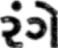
રંગે
